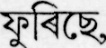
ফুৰিছে,
